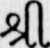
શ્રી
